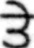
ਤੇ
